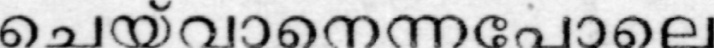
ചെയ്വാനെന്നപോലെ
